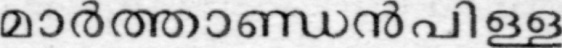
മാര്‍ത്താണ്ഡന്‍പിള്ള
